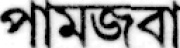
পামজবা
